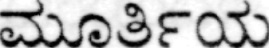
ಮೂರ್ತಿಯ
